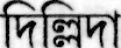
দিল্লিদা
